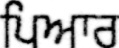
ਪਿਆਰ
